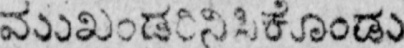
ಮುಖಂಡರಿನಿಸಿಕೊಂಡು
